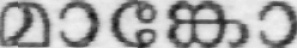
മാങ്കോ
